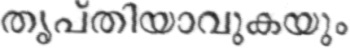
തൃപ്തിയാവുകയും
